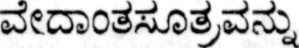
ವೇದಾಂತಸೂತ್ರವನ್ನು
